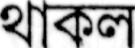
থাকল
